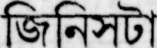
জিনিসটা
